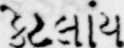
કેટલાંય
